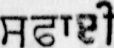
ਸਫਾਈ
